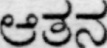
ಆತನ
